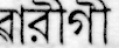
ৱারীগী
